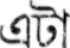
এটা
